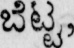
ಬೆಟ್ಟ,
